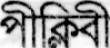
পীক্লিবী
